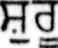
ਸ਼ੁਰੂ
